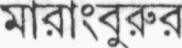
মারাংবুরুর
